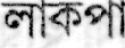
লাকপা
